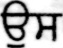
ਉਸ
